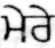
ਮੇਰੇ
